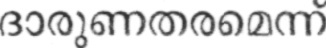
ദാരുണതരമെന്ന്
